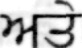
ਅਤੇ
